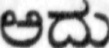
ಅದು
